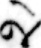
જે
